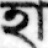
হা
